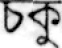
চকু
